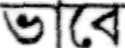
ভাবে
